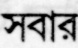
সবার
